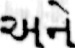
અને
